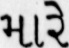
મારે
